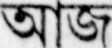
আজ
